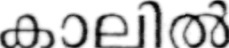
കാലില്‍
